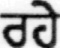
ਰਹੇ
